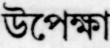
উপেক্ষা
